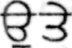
ਉਤੇ
